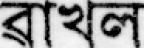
ৱাখল
